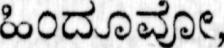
ಹಿಂದೂವೋ,
